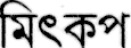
মিৎকপ
